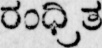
ರಂಧ್ರಿತ
